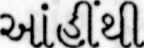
આંહીંથી
